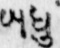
બધું
